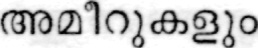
അമീറുകളും
